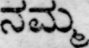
ನಮ್ಮ
